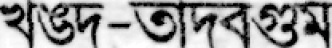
খঙদ-তাদবগুম
